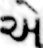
એ
